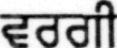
ਵਰਗੀ
